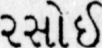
રસોઈ
